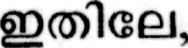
ഇതിലേ,
